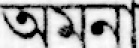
অমনা
